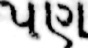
પણ
